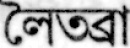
লৈতব্রা
